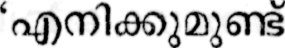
‘എനിക്കുമുണ്ട്
